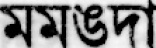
মমঙদা
